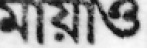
মায়াও
